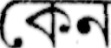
কেন
